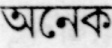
অনেক
